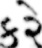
કરે
